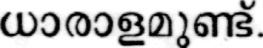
ധാരാളമുണ്ട്.
